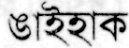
ঙাইহাক
